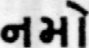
નમો
